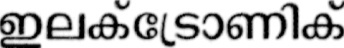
ഇലക്ട്രോണിക്
